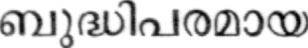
ബുദ്ധിപരമായ
